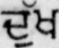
ਦੁੱਖ
